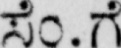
ಸೆಂ.ಗೆ
